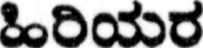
ಹಿರಿಯರ
